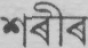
শৰীৰ
